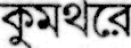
কুমথরে
